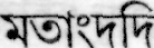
মতাংদদি
